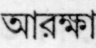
আরক্ষা
